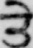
ਤੇ
